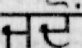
ਜਦੋਂ
